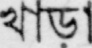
খাড়া
